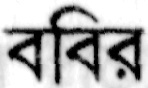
ববির
